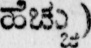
ಹೆಚ್ಚು)
